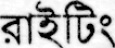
রাইটিং
